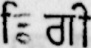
ਡਿਗੀ
